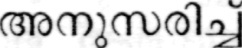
അനുസരിച്ച്
